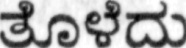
ತೊಳೆದು
